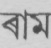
ৰাম
